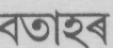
বতাহৰ
